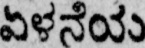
ಏಳನೆಯ
